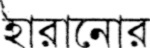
হারানোর
